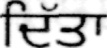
ਦਿੱਤਾ
